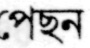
পেছন
